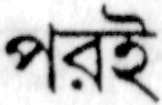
পরই
